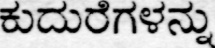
ಕುದುರೆಗಳನ್ನು
